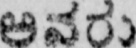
ಅವರು
